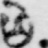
છે.
